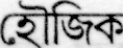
হৌজিক
